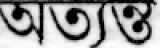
অত্যন্ত
